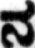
ನ
